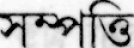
সম্পত্তি
